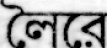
লৈরে
